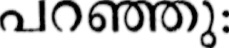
പറഞ്ഞു:
